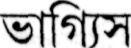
ভাগ্যিস
